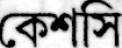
কেশসি
